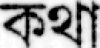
কথা
